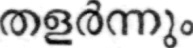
തളര്‍ന്നും
